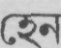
হেন
